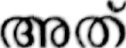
അത്
